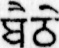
ਬੈਠੇ
